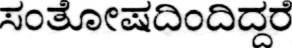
ಸಂತೋಷದಿಂದಿದ್ದರೆ
